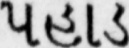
પહાડ
